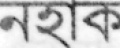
নহাক
